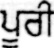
ਪੂਰੀ
